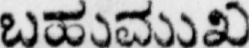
ಬಹುಮುಖ
